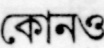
কোনও
